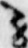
કે
